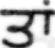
ਤਾਂ
